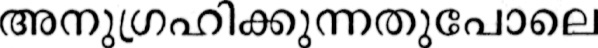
അനുഗ്രഹിക്കുന്നതുപോലെ
